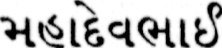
મહાદેવભાઈ
